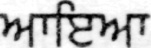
ਆਇਆ
